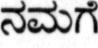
ನಮಗೆ
